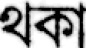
থকা
